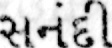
સનંદી
